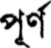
পূর্ণ
